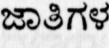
ಜಾತಿಗಳ
